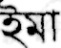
ইমা
